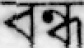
বন্ধ
